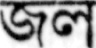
জল
